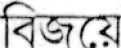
বিজয়ে
